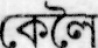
কেলৈ
